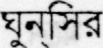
ঘুন্‌সির
